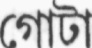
গোটা
